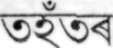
তহঁতৰ
